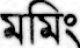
মমিং
